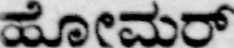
ಹೋಮರ್
